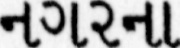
નગરના
